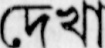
দেখা
